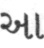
આ
